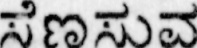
ಸೆಣಸುವ
